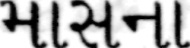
માસના
